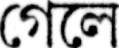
গেলে
